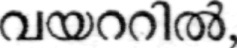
വയററില്‍,
